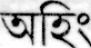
অহিং
